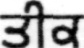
ਤੀਕ
